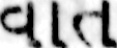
વાત
